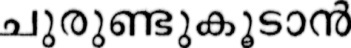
ചുരുണ്ടുകൂടാന്‍
